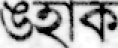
ঙহাক
